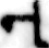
ન
